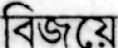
বিজয়ে
